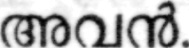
അവന്‍.
